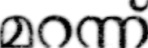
മറന്ന്
